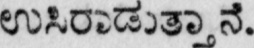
ಉಸಿರಾಡುತ್ತಾನೆ.
